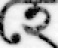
হে
